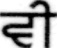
ਵੀ
